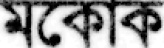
মকোক
